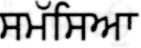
ਸਮੱਸਿਆ
